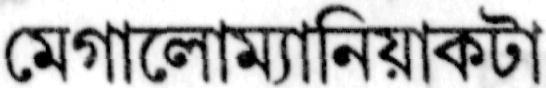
মেগালোম্যানিয়াকটা
